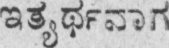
ಇತ್ಯರ್ಥವಾಗ
